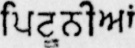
ਪਿਟੂਨੀਆਂ
